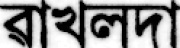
ৱাখলদা
